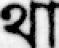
থা
